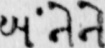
બંનેનો
